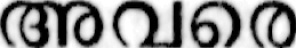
അവരെ
